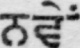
ਨਵੇਂ
